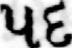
પદ
